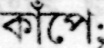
কাঁপে;
